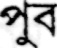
পুব
